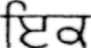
ਇਕ
